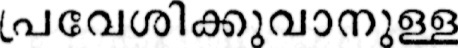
പ്രവേശിക്കുവാനുള്ള
